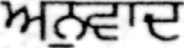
ਅਨੁਵਾਦ
